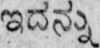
ಇದನ್ನು
